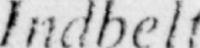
Indhelt
